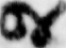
જ
